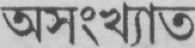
অসংখ্যাত
